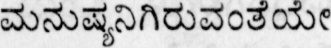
ಮನುಷ್ಯನಿಗಿರುವಂತೆಯೇ
